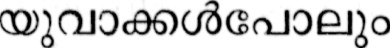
യുവാക്കള്‍പോലും
